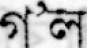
গ'ল
